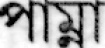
পাম্না
